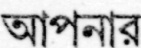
আপনার
